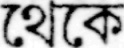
থেকে
